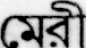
মেরী
